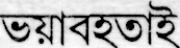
ভয়াবহতাই
